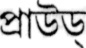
প্রাউড্
